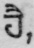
ਹੈ,
